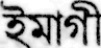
ইমাগী
